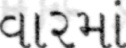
વારમાં
